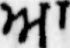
ਆ
